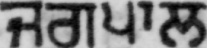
ਜਗਪਾਲ
